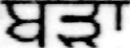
ਬੜਾ
